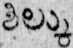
ಶಿಲ್ಕು
